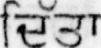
ਦਿੱਤਾ
